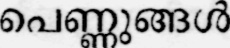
പെണ്ണുങ്ങള്‍
